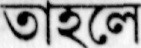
তাহলে
